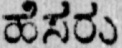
ಹೆಸರು
